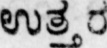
ಉತ್ತರ
